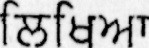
ਲਿਖਿਆ
